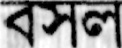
বসল
